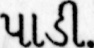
પાડી.
